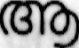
ആ
